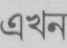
এখন
